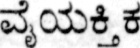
ವೈಯಕ್ತಿಕ
